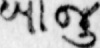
બાજુ
